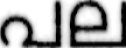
പല
